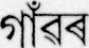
গাঁৱৰ
